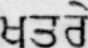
ਖਤਰੇ
